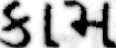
કામ
